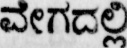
ವೇಗದಲ್ಲಿ
